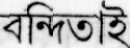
বন্দিতাই
